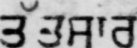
ਤੱਤਸਾਰ
